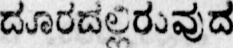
ದೂರದಲ್ಲಿರುವುದ
